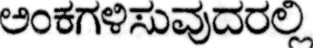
ಅಂಕಗಳಿಸುವುದರಲ್ಲಿ
